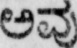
ಅವು
